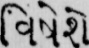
વિષેશે
